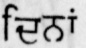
ਦਿਨਾਂ
